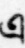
এ
